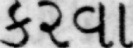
કરવા
